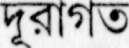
দূরাগত
